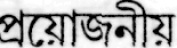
প্রয়োজনীয়
